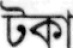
টকা
